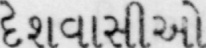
દેશવાસીઓ
